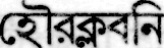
হৌরক্লবনি
